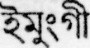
ইমুংগী
